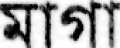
মাগা
